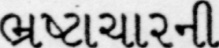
ભ્રષ્ટાચારની
